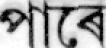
পাৰে
